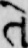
તે
